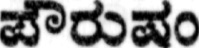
ಪೌರುಷ೦
